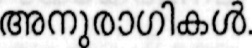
അനുരാഗികള്‍.
